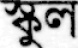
স্কুল
